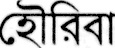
হৌরিবা
